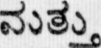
ಮತ್ತು
